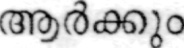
ആര്‍ക്കും
